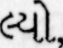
લ્યો,
